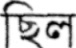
ছিল
